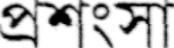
প্রশংসা
